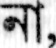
না,
